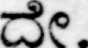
ದೇ.
